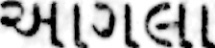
આગલા
